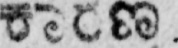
ಕಾರಣ.
